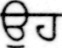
ਉਹ
